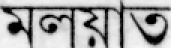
মলয়াত
